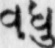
વધુ
